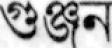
গুঞ্জন
